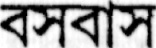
বসবাস
